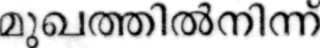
മുഖത്തില്‍നിന്ന്
